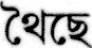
থৈছে
